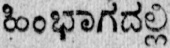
ಹಿಂಭಾಗದಲ್ಲಿ
